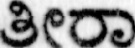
ತೀರಾ
